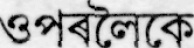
ওপৰলৈকে
